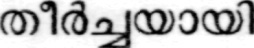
തീര്‍ച്ചയായി
